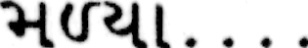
મળ્યા....
